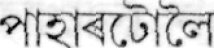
পাহাৰটোলৈ
